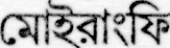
মোইরাংফি
